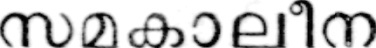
സമകാലീന
